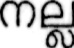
നല്ല
